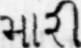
મારી
